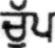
ਚੁੱਪ
